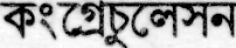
কংগ্রেচুলেসন
